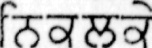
ਨਿਕਲਕੇ
